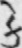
કે
